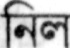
নিল
